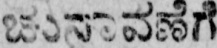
ಚುನಾವಣೆಗೆ
